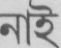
নাই
